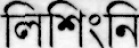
লিশিংনি
